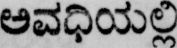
ಅವಧಿಯಲ್ಲಿ
